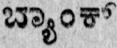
ಬ್ಯಾಂಕ್
